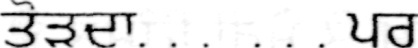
ਤੋੜਦਾ.........ਪਰ
